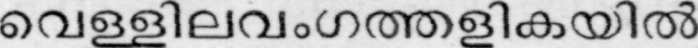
വെള്ളിലവംഗത്തളികയില്‍
